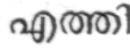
എത്തി
